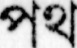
পথ
